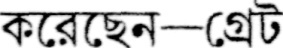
করেছেন–গ্রেট
